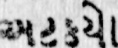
અટક્યો
